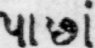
પાછાં
